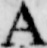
A
